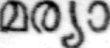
മര്യാ
